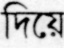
দিয়ে
